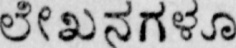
ಲೇಖನಗಳೂ
